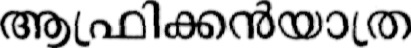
ആഫ്രിക്കന്‍യാത്ര
